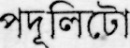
পদূলিটো
